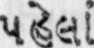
પહેલાં
